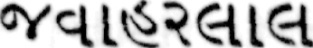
જવાહરલાલ
